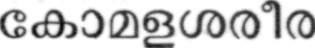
കോമളശരീര
